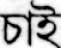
চাই
